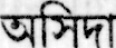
অসিদা
